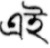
এই
